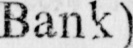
Bank)
